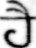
ਹੈ
